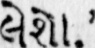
લેશો.'
